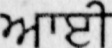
ਆਈ
